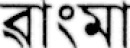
ৱাংমা
